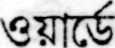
ওয়ার্ডে
